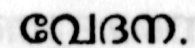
വേദന.
